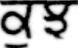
ਕੁਝ
